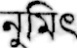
নুমিৎ
